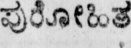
ಪುರೋಹಿತ
